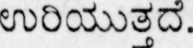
ಉರಿಯುತ್ತದೆ.
